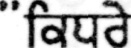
''ਕਿਧਰੇ
